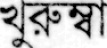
খুরুম্বা
